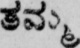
ತಮ್ಮ
